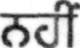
ਨਹੀਂ
